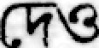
দেও
